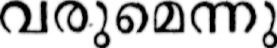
വരുമെന്നു
